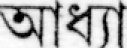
আধ্যা
